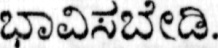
ಭಾವಿಸಬೇಡಿ.
